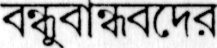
বন্ধুবান্ধবদের
